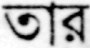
তার
